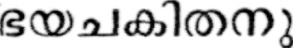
ഭയചകിതനു
